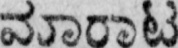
ಮಾರಾಟ
